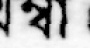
থম্বা
